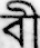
বী
